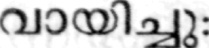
വായിച്ചു:
